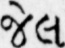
જેલ
